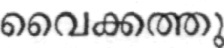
വൈക്കത്തു
